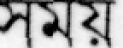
সময়
